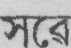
সৱে
